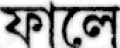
ফালে
